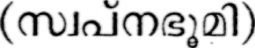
(സ്വപ്നഭൂമി)
